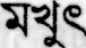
মখুৎ
